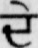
ਦੇ
